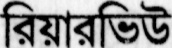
রিয়ারভিউ
